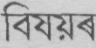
বিষয়ৰ
